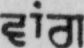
ਵਾਂਗ
